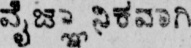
ವೈಜ್ಞಾನಿಕವಾಗಿ
